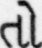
તો
